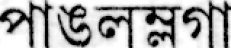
পাঙলম্লগা
